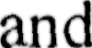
and
